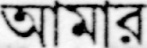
আমার
